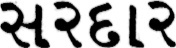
સરદાર
